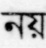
নয়
